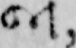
જા,
